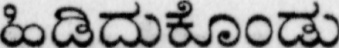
ಹಿಡಿದುಕೊಂಡು
